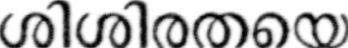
ശിശിരതയെ
